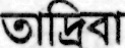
তাদ্রিবা
